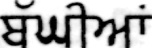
ਬੱਘੀਆਂ
